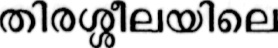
തിരശ്ശീലയിലെ
